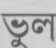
ভুল
